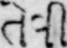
તેવી
